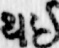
થઈ
